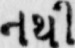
નથી
